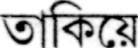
তাকিয়ে
